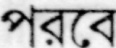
পরবে
